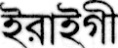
ইরাইগী
